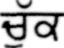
ਚੁੱਕ
